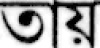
তায়
